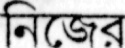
নিজের
